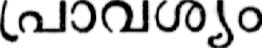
പ്രാവശ്യം
